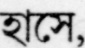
হাসে,
